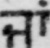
ਜਾਂ
